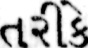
તરીકે
